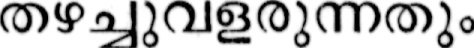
തഴച്ചുവളരുന്നതും
